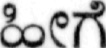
ಹೀಗೆ
